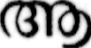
ആ
